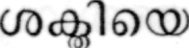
ശക്തിയെ
